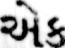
એક
